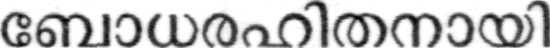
ബോധരഹിതനായി
